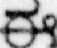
ಈ
